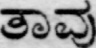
ತಾವು
